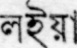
লইয়া
